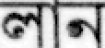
লান
